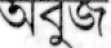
অবুজ
